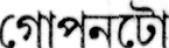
গোপনটো
